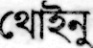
থোইনু
